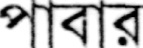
পাবার
